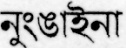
নুংঙাইনা
